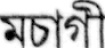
মচাগী
